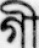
গী
